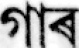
গাৰ
